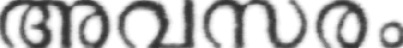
അവസരം
